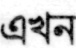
এখন
